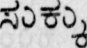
ಸುಕ್ಕು
